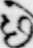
છે
